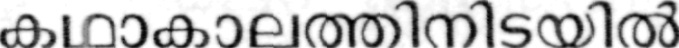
കഥാകാലത്തിനിടയില്‍
